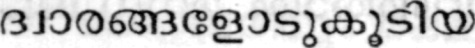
ദ്വാരങ്ങളോടുകൂടിയ
